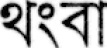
থংবা
